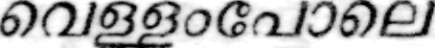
വെള്ളംപോലെ
